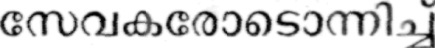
സേവകരോടൊന്നിച്ച്
